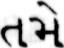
તમે
